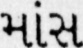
માંસ
